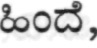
ಹಿಂದೆ,
